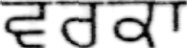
ਵਰਕਾ
